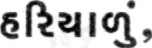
હરિયાળું,
